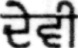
ਦੇਵੀ
